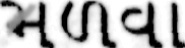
મળવા
